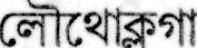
লৌথোক্লগা
